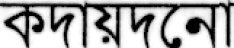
কদায়দনো
